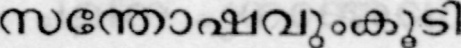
സന്തോഷവുംകൂടി
